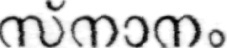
സ്നാനം
